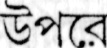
উপরে
